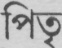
পিতৃ
